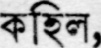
কহিল,
